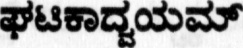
ಘಟಿಕಾದ್ವಯಮ್
